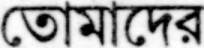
তোমাদের
